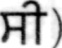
ਸੀ)
